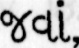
જવાં,
